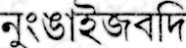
নুংঙাইজবদি
